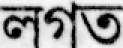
লগত
